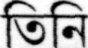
তিনি
